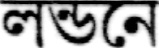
লন্ডনে
